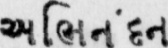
અભિનંદન
